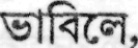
ভাবিলে,
